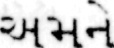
અમને
